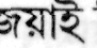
জয়াই
